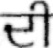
ਦੀ
